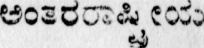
ಅಂತರರಾಷ್ಟ್ರೀಯ
